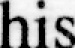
his
